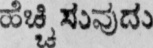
ಹೆಚ್ಚಿಸುವುದು
